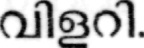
വിളറി.
